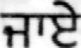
ਜਾਏ
